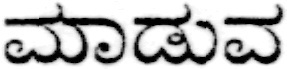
ಮಾಡುವ
